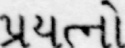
પ્રયત્નો
